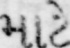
માટે
